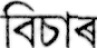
বিচাৰ
